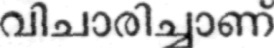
വിചാരിച്ചാണ്
